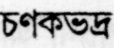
চণকভদ্র
